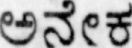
ಅನೇಕ
